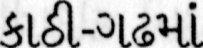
કાઠી-ગઢમાં
